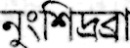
নুংশিদ্রব্রা
